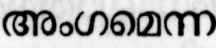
അംഗമെന്ന
